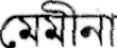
মেমীনা
